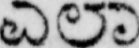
ಎಲಾ
